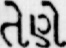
તેણે
